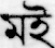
মই
